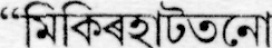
"মিকিৰহাটতনো
